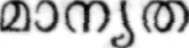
മാന്യത
